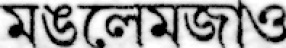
মঙলেমজাও
